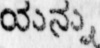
ಯನ್ನು
